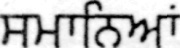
ਸਮਾਨਿਆਂ
